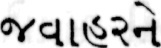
જવાહરને
